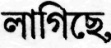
লাগিছে,
